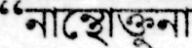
“নান্থোক্তুনা
